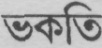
ভকতি
